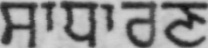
ਸਾਧਾਰਣ
